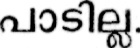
പാടില്ല.
